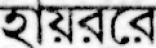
হায়ররে
